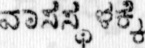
ವಾಸಸ್ಥಳಕ್ಕೆ
